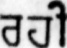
ਰਹੀ
